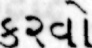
કરવો
